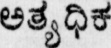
ಅತ್ಯಧಿಕ
